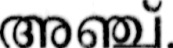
അഞ്ച്.
